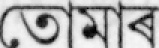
তোমাৰ
